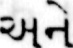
અને
